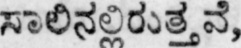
ಸಾಲಿನಲ್ಲಿರುತ್ತವೆ,
